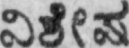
ವಿಶೇಷ
